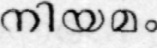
നിയമം
